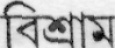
বিশ্রাম
